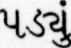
પડ્યું
